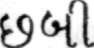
છબી
